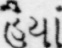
હૈયાં
